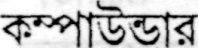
কম্পাউন্ডার
